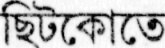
ছিটকোতে
